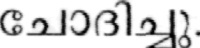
ചോദിച്ചു.
